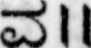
ವ||
